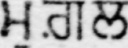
ਮੁਗ਼ਲ
